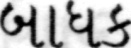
બાધક
